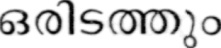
ഒരിടത്തും
